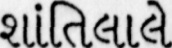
શાંતિલાલે
